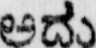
ಅದು
